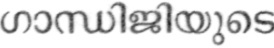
ഗാന്ധിജിയുടെ
